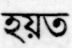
হয়ত
